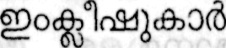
ഇംക്ലീഷുകാര്‍
